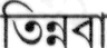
তিন্নবা
